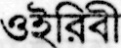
ওইরিবী
